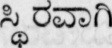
ಸ್ಥಿರವಾಗಿ
